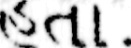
હતા.
